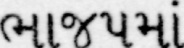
ભાજપમાં
